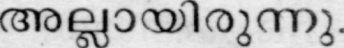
അല്ലായിരുന്നു.
